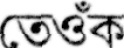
তেওঁক
